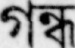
গন্ধ
